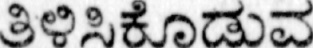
ತಿಳಿಸಿಕೊಡುವ
